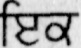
ਇਕ
